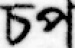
চপ
